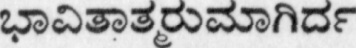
ಭಾವಿತಾತ್ಮರುಮಾಗಿರ್ದ
